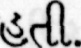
હતી.
